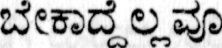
ಬೇಕಾದ್ದೆಲ್ಲವೂ
